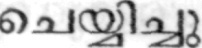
ചെയ്യിച്ചു
